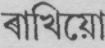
ৰাখিয়ো
